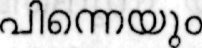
പിന്നെയും
